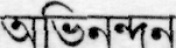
অভিনন্দন
